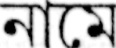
নামে
